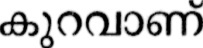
കുറവാണ്
